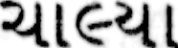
ચાલ્યા
